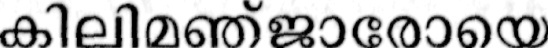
കിലിമഞ്ജാരോയെ
